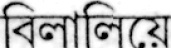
বিলালিয়ে
